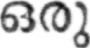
ഒരു
